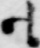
ન
